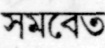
সমবেত
